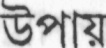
উপায়
